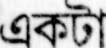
একটা
